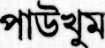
পাউখুম
